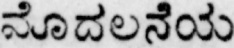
ಮೊದಲನೆಯ
